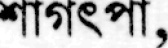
শাগৎপা,
